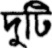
দুটি
